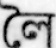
লৈ
